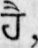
ਹੈ,
